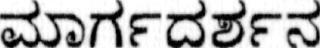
ಮಾರ್ಗದರ್ಶನ
